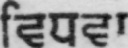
ਵਿਧਵਾ
